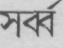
সৰ্ব্ব
